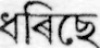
ধৰিছে
